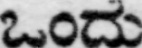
ಒ೦ದು
